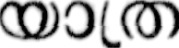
യാത്ര
